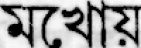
মখোয়
